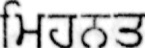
ਮਿਹਨਤ
